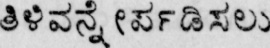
ತಿಳಿವನ್ನೇರ್ಪಡಿಸಲು
